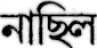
নাছিল
